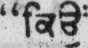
''ਕਿਉਂ
